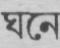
ঘনে
